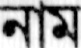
নাম
